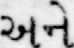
અને
